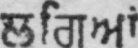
ਲਗਿਆਂ
